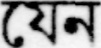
যেন
